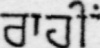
ਰਾਹੀਂ
